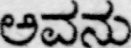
ಅವನು
